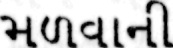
મળવાની
